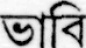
ভাবি
